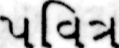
પવિત્ર
